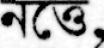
নত্তে,
